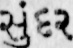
સુંદર
